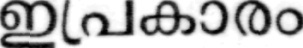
ഇപ്രകാരം
